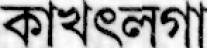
কাখৎলগা
